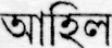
আহিল
